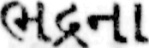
ભદ્રના
